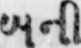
બની
